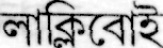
লাক্লিবোই
